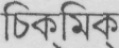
চিক্‌মিক্
